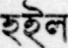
হইল
